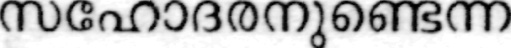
സഹോദരനുണ്ടെന്ന
